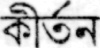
কীর্তন
